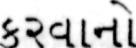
કરવાનો
